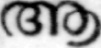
ആ
